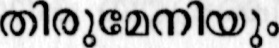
തിരുമേനിയും
